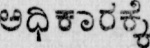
ಅಧಿಕಾರಕ್ಕೆ
